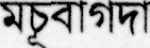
মচূবাগদা
